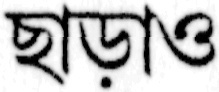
ছাড়াও
